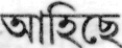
আহিছে
